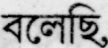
বলেছি,
